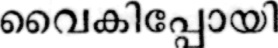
വൈകിപ്പോയി
